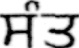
ਸੰਤ
